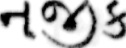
નજીક
